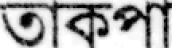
তাকপা
